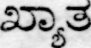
ಖ್ಯಾತ
